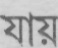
যায়
